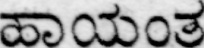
ಹಾಯಂತ
